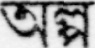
অল্প
